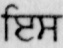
ਇਸ
